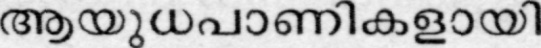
ആയുധപാണികളായി
